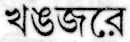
খঙজরে
